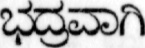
ಭದ್ರವಾಗಿ
